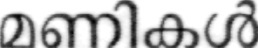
മണികള്‍
